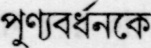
পুণ্যবর্ধনকে
